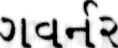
ગવર્નર
